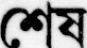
শেষ
